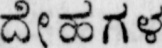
ದೇಹಗಳ
